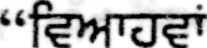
''ਵਿਆਹਵਾਂ
